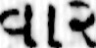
વાર
